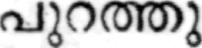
പുറത്തു
